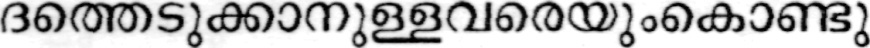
ദത്തെടുക്കാനുള്ളവരെയുംകൊണ്ടു
